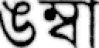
ঙম্বা
